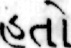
હતો
